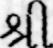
શ્રી
